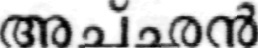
അച്ഛന്‍
